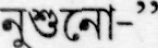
নুশুনো-"
